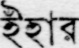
ইঁহার
